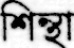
শিন্থা
